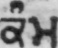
ਕੰਮ
